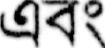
এবং
